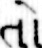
તો
